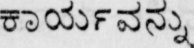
ಕಾರ್ಯವನ್ನು
